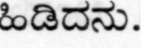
ಹಿಡಿದನು.
